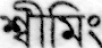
শ্বীমিং
